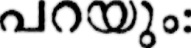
പറയും:
